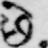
છે.
